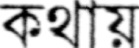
কথায়
